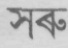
সৰু
